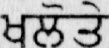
ਖਲੋਤੇ
